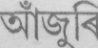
আঁজুৰি
